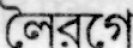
লৈরগে
